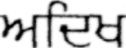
ਅਦਿਖ
